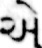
એ
